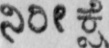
ನಿರೀಕ್ಷೆ
